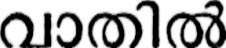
വാതില്‍
